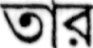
তার
